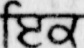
ਇਕ
